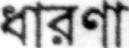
ধারণা
